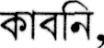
কাবনি,
